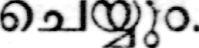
ചെയ്യും.
